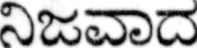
ನಿಜವಾದ
